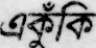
একুঁকি
